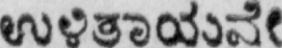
ಉಳಿತಾಯವೇ
